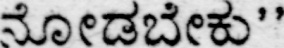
ನೋಡಬೇಕು"
